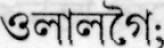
ওলালগৈ;
